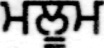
ਮਲੂਮ
